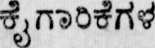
ಕೈಗಾರಿಕೆಗಳ
